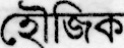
হৌজিক
